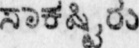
ಸಾಕಷ್ಟಿರು
